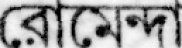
রোমেন্দা
